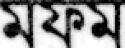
মফম
